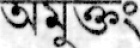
অমুক্তং
